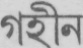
গহীন
